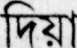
দিয়া
